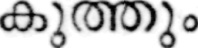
കുത്തും
